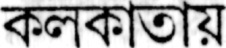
কলকাতায়
